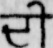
ਦੀ
